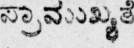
ಪ್ರಾಮುಖ್ಯತೆ
